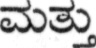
ಮತ್ತು
